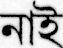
নাই
